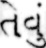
તેવું
